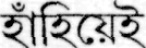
হাঁহিয়েই
